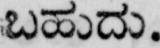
ಬಹುದು.
